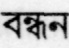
বন্ধন
